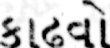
કાઢવો
